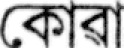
কোৱা
